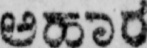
ಆಹಾರ
